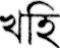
খহি
